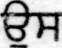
ਉਸ
